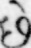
છે
